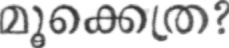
മൂക്കെത്ര?
